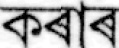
কৰাৰ
